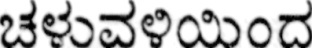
ಚಳುವಳಿಯಿಂದ
